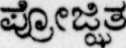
ಪ್ರೋಜ್ಝಿತ
